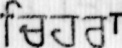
ਚਿਹਰਾ
